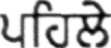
ਪਹਿਲੇ
